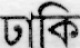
ঢাকি
